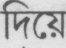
দিয়ে
